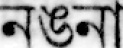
নঙনা
